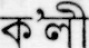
ক'লী
